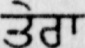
ਤੇਰਾ
